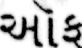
ઑફ
